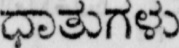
ಧಾತುಗಳು
